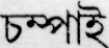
চম্পাই
